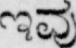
ಇವು
